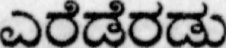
ಎರೆಡೆರಡು
